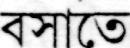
বসাতে
